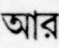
আর
